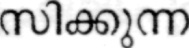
സിക്കുന്ന
